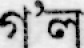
গ'ল
